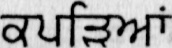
ਕਪੜਿਆਂ
